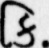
કિ.
